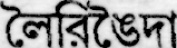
লৈরিঙৈদা
